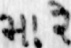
મારે
